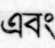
এবং
